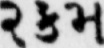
રકમ
